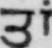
ਤਾਂ
